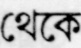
থেকে
